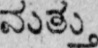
ಮತ್ತು
